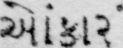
ઓંકારં
